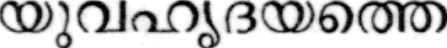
യുവഹൃദയത്തെ
